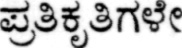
ಪ್ರತಿಕೃತಿಗಳೇ
